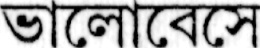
ভালোবেসে
